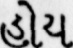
હોય
